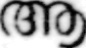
ആ
